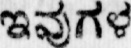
ಇವುಗಳ
